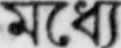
মধ্যে
